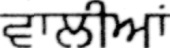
ਵਾਲੀਆਂ
